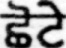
ਛੋਟੇ
